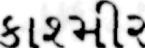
કાશ્મીર
